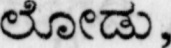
ಲೋಡು,
